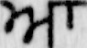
ਆ
